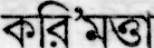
করি’মত্তা
